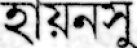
হায়নসু
